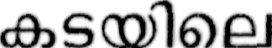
കടയിലെ
